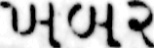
ખબર
